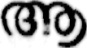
ആ
